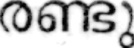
രണ്ടു
